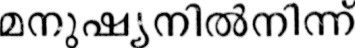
മനുഷ്യനില്‍നിന്ന്
